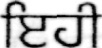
ਇਹੀ
